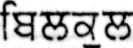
ਬਿਲਕੁਲ
